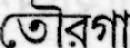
তৌরগা
